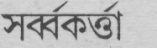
সৰ্ব্বকৰ্ত্তা
